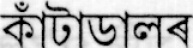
কাঁটাডালৰ
